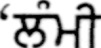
'ਲੰਮੀ
